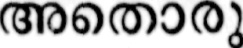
അതൊരു
